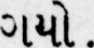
ગયો.
